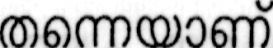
തന്നെയാണ്
